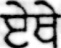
ਏਥੇ
